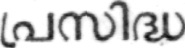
പ്രസിദ്ധ
